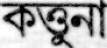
কত্তুনা
